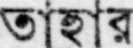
তাহার
